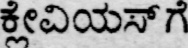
ಕ್ಲೇವಿಯಸ್‌ಗೆ
